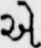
એ
